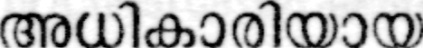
അധികാരിയായ
